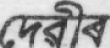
দেৱীৰ
